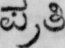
ಪ್ರತಿ
